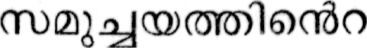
സമുച്ചയത്തിന്റെ
